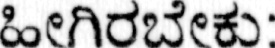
ಹೀಗಿರಬೇಕು:
